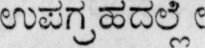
ಉಪಗ್ರಹದಲ್ಲೇ
